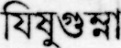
যিষুগুম্না
